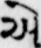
એ
